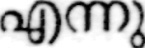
എന്നു
